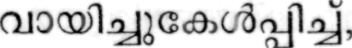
വായിച്ചുകേള്‍പ്പിച്ച്,
